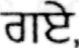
ਗਏ,
